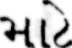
માટે
